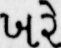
ખરે
